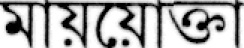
মায়য়োক্তা
